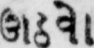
ઊઠવો
